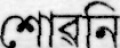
শোৱনি
